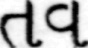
તવ
